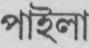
পাইলা
